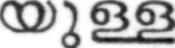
യുള്ള
